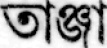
তাঞ্জা
